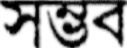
সম্ভব
